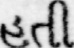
હતી
